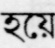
হয়ে
